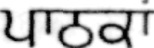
ਪਾਠਕਾਂ
